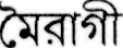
মৈরাগী
